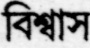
বিশ্বাস
